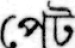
পেট
